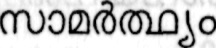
സാമര്‍ത്ഥ്യം
